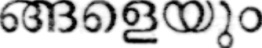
ങ്ങളെയും
